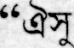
“ঐসু
